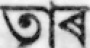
তাৰ
